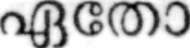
ഏതോ
